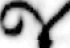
જ
